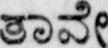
ತಾವೇ
